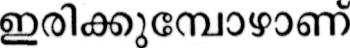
ഇരിക്കുമ്പോഴാണ്
